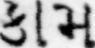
કામ
